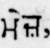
ਮੇਜ਼,
